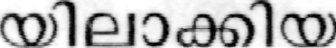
യിലാക്കിയ
